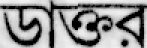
ডাক্তর
